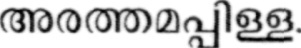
അരത്തമപ്പിള്ള.
